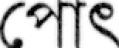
পোৎ
